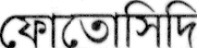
ফোতোসিদি
